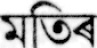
মতিৰ
